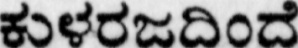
ಕುಳರಜದಿಂದೆ
